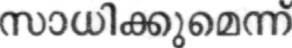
സാധിക്കുമെന്ന്
